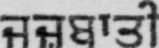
ਜਜ਼ਬਾਤੀ
